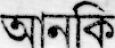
আনকি
